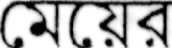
মেয়ের
